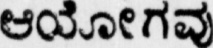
ಆಯೋಗವು
